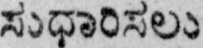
ಸುಧಾರಿಸಲು
